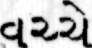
વચ્ચે
